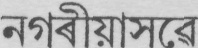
নগৰীয়াসৱে
